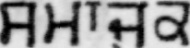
ਸਮਾਜਕ
